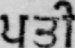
ਪਤੀ
